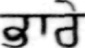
ਭਾਰੇ
